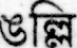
ঙল্লি
